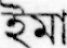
ইমা
